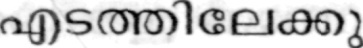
എടത്തിലേക്കു
